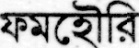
ফমহৌরি
